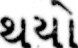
થયો
